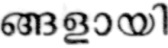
ങ്ങളായി
